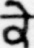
ਕੇ
